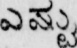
ಎಷ್ಟು
